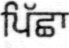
ਪਿੱਛਾ
